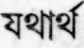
যথার্থ
